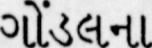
ગોંડલના
